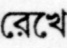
রেখে
